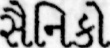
સૈનિકો
